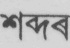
শব্দৰ
